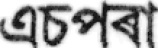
এচপৰা
